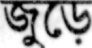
জুড়ে
